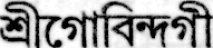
শ্রীগোবিন্দগী
